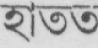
হাতত
